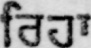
ਰਿਹਾ
